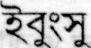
ইবুংসু
